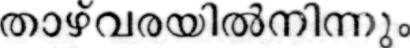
താഴ്വരയില്‍നിന്നും
